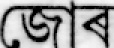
জোৰ
